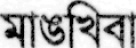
মাঙখিবা
